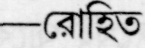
–রোহিত
